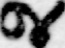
જ
